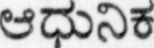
ಆಧುನಿಕ
